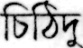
চিঠিদু
